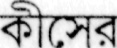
কীসের
